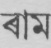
ৰাম
